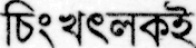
চিংখৎলকই
